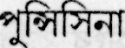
পুন্সিসিনা
